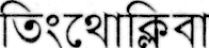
তিংথোক্লিবা
